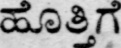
ಹೊತ್ತಿಗೆ
